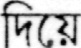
দিয়ে
